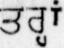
ਤਰ੍ਹਾਂ
